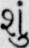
શું
